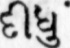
દીધું
